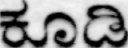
ಕೂಡಿ
